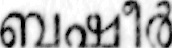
ബഷീര്‍
